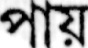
পায়
